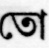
তো
